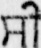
ਸੀ
